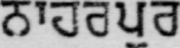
ਨਾਹਰਪੁਰ
